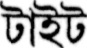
টাইট
